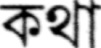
কথা
